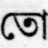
তো
